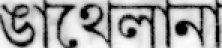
ঙাথেলানা
